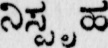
ನಿಸ್ಪೃಹ
